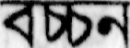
বচ্চন
